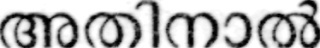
അതിനാല്‍
